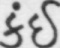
કંઈ
